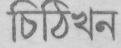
চিঠিখন
